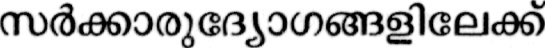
സര്‍ക്കാരുദ്യോഗങ്ങളിലേക്ക്
